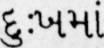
દુઃખમાં
